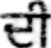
ਦੀ
